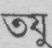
তযু
